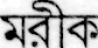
মরীক
